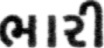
ભારી
